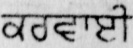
ਕਰਵਾਈ
